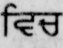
ਵਿਚ
